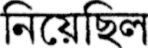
নিয়েছিল
